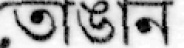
তোঙান
